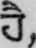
ਹੈ,
